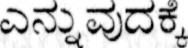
ಎನ್ನುವುದಕ್ಕೆ
